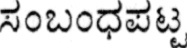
ಸಂಬಂಧಪಟ್ಟ
